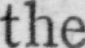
the
